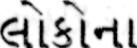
લોકોના
